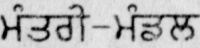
ਮੰਤਰੀ-ਮੰਡਲ
